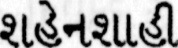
શહેનશાહી
